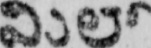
ಮಿಲ್
